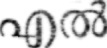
എല്‍
